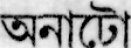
অনাটো
